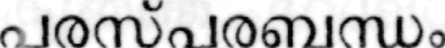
പരസ്പരബന്ധം
